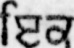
ਇਕ
